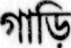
গাড়ি
